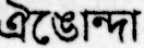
ঐঙোন্দা
